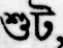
শুট,
